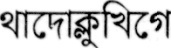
থাদোক্লুখিগে
